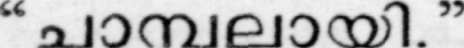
"ചാമ്പലായി."
